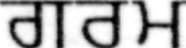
ਗਰਮ
